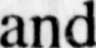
and
